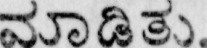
ಮಾಡಿತು.
